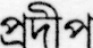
প্রদীপ
